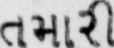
તમારી
